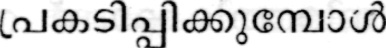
പ്രകടിപ്പിക്കുമ്പോള്‍
